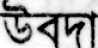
উবদা
